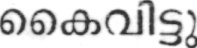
കൈവിട്ടു
